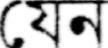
যেন
